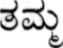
ತಮ್ಮ
